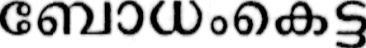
ബോധംകെട്ട
